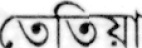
তেতিয়া
